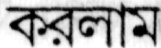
করলাম
